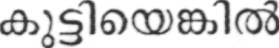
കുട്ടിയെങ്കില്‍
